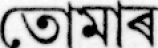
তোমাৰ
